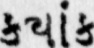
ક્યાંક
